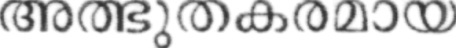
അത്ഭുതകരമായ
